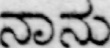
ನಾನು
